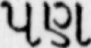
પણ
